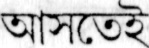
আসতেই
